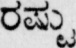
ರಷ್ಟು
